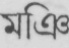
মঞি
